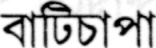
বাটিচাপা
